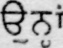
ਉਨ੍ਹਾਂ
